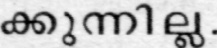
ക്കുന്നില്ല.
